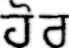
ਹੋਰ
